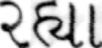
રહ્યા
